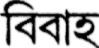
বিবাহ
